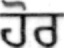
ਹੋਰ
